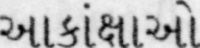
આકાંક્ષાઓ
